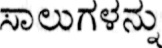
ಸಾಲುಗಳನ್ನು
